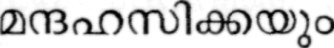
മന്ദഹസിക്കയും
